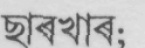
ছাৰখাৰ;
